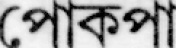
পোকপা
